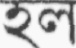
হল
